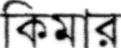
কিমার
